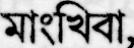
মাংখিবা,
